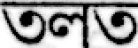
তলত
